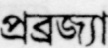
প্রব্রজ্যা
